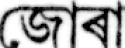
জোৰা
